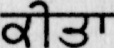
ਕੀਤਾ
